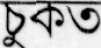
চুকত
